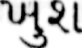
ખુશ
